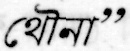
থৌনা”
